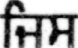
ਜਿਸ
